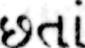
છતાં
